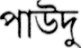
পাউদু
